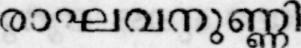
രാഘവനുണ്ണി
